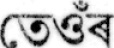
তেওঁৰ
